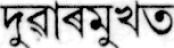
দুৱাৰমুখত
